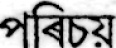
পৰিচয়
